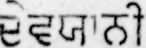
ਦੇਵਯਾਨੀ
